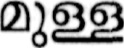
മുള്ള
